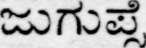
ಜುಗುಪ್ಸೆ
